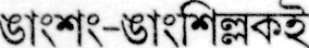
ঙাংশং-ঙাংশিল্লকই
